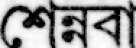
শেন্নবা
